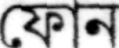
ফোন
